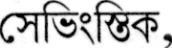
সেভিংস্তিক,
